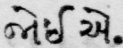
જેઈએ
